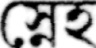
স্নেহ
